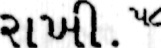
રાખી.૫૮
